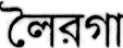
লৈরগা
